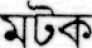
মটক
